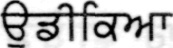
ਉਡੀਕਿਆ
